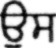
ਉਸ
